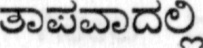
ತಾಪವಾದಲ್ಲಿ
